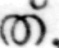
ത്,
